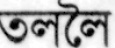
তললৈ
